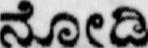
ನೋಡಿ
